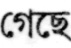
গেছে
